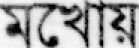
মখোয়
